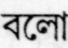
বলো
